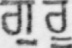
ਗੁਰੂ
